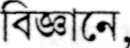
বিজ্ঞানে,
